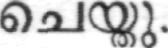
ചെയ്തു.
